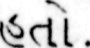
હતો.
